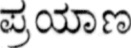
ಪ್ರಯಾಣ
